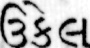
ઉકેલ
